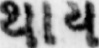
થાય
